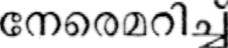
നേരെമറിച്ച്
